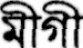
মীগী
